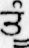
ਤੂੰ
